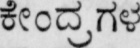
ಕೇಂದ್ರಗಳ
